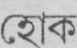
হোক
